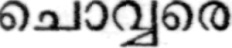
ചൊവ്വരെ
